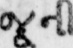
જૂની
